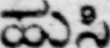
ಹುಸಿ
